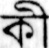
কী
